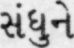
સંધુને
